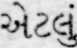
એટલું
